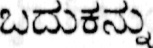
ಬದುಕನ್ನು
